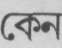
কেন
